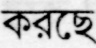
করছে
